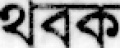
থবক
